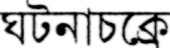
ঘটনাচক্রে
